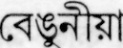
বেঙুনীয়া
